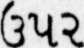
ઉપર
